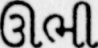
ઊભી
